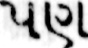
પણ
